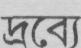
দ্ৰব্যে
